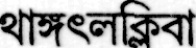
থাঙ্গৎলক্লিবা
